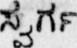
ಸ್ವರ್ಗ
